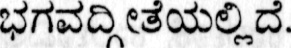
ಭಗವದ್ಗೀತೆಯಲ್ಲಿದೆ.
